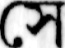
সে
